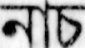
নাচ
